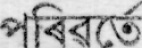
পৰিৱর্তে
